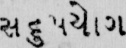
સદુપયોગ
